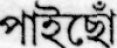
পাইছোঁ
